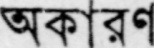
অকারণ
